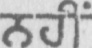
ਨਹੀਂ
